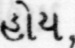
હોય,
